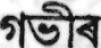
গভীৰ
